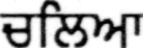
ਚਲਿਆ
